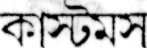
কাস্টমস
